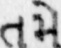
તમે
